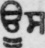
ਊਸ
